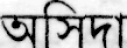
অসিদা
